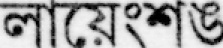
লায়েংশঙ
